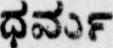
ಧರ್ಮ
